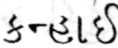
કન્હાઈ
